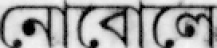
নোবোলে
